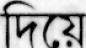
দিয়ে
